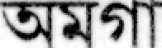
অমগা
